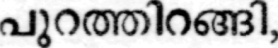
പുറത്തിറങ്ങി,
